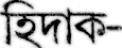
হিদাক-
